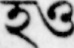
হও
